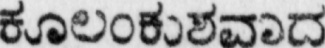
ಕೂಲಂಕುಶವಾದ
